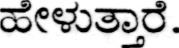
ಹೇಳುತ್ತಾರೆ.
